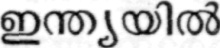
ഇന്ത്യയില്‍
